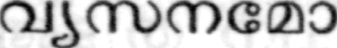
വ്യസനമോ
